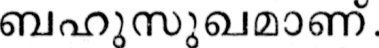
ബഹുസുഖമാണ്.
